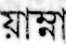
য়াম্না
